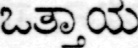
ಒತ್ತಾಯ
